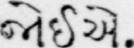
જોઈએ.
